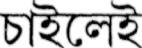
চাইলেই
